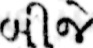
બીજે
